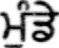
ਮੁੰਡੇ
